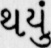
થયું
